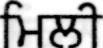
ਮਿਲੀ
